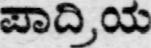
ಪಾದ್ರಿಯ
